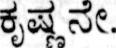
ಕೃಷ್ಣನೇ.
